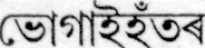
ভোগাইহঁতৰ
